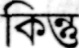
কিন্তু
